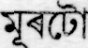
মূৰটো
